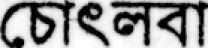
চোৎলবা
